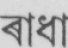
ৰাধা
